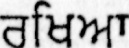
ਰਖਿਆ
